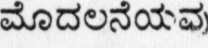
ಮೊದಲನೆಯವು
